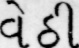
વેઠી
